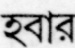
হবার
